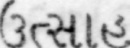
ઉત્સાહ
